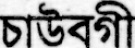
চাউবগী
